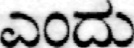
ಎಂದು
